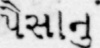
પૈસાનું
